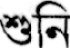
শুনি
